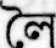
লৈ
